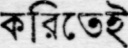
করিতেই
